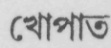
খোপাত
